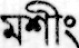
মশীং
